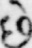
છે
